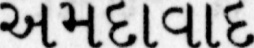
અમદાવાદ
